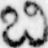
ಬಿ
